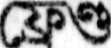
ফ্রেণ্ড
